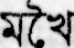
মখৈ
